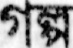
গল্প
